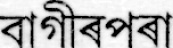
বাগীৰপৰা
